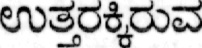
ಉತ್ತರಕ್ಕಿರುವ
